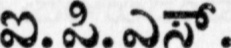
ಐ.ಪಿ.ಎಸ್.
